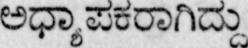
ಅಧ್ಯಾಪಕರಾಗಿದ್ದು
